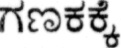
ಗಣಕಕ್ಕೆ
